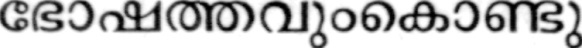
ഭോഷത്തവുംകൊണ്ടു
